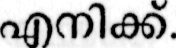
എനിക്ക്.
